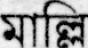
মাল্লি
